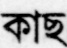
কাছ
